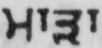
ਮਾੜਾ
